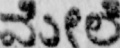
ಮೇಲೆ
